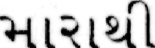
મારાથી
